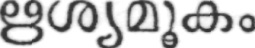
ഋശ്യമൂകം
